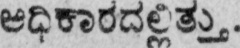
ಅಧಿಕಾರದಲ್ಲಿತ್ತು.
